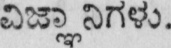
ವಿಜ್ಞಾನಿಗಳು.
